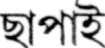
ছাপাই
